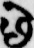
છે
